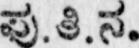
ಪು.ತಿ.ನ.
